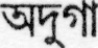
অদুগা
